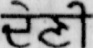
ਦੇਣੀ
